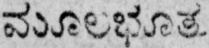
ಮೂಲಭೂತ
